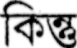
কিন্তু
